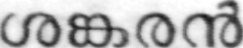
ശങ്കരന്‍
